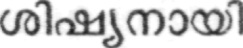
ശിഷ്യനായി
